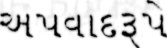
અપવાદરૂપે
